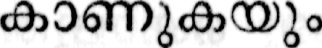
കാണുകയും
